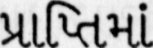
પ્રાપ્તિમાં
